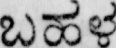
ಬಹಳ
